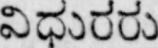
ವಿಧುರರು
